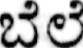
ಬೆಲೆ
